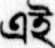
এই
